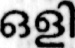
ഒളി
